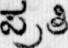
ಪ್ರತಿ
